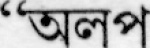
"অলপ
